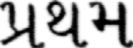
પ્રથમ
